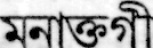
মনাক্তগী
